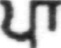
ਪਾ
